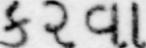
કરવા
